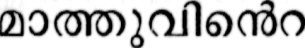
മാത്തുവിന്റെ
